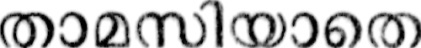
താമസിയാതെ
